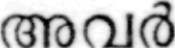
അവര്‍
